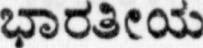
ಭಾರತೀಯ
